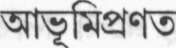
আভূমিপ্রণত
